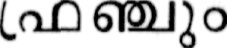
ഫ്രഞ്ചും
